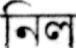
নিল
